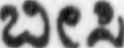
ಬೀಸಿ
